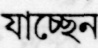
যাচ্ছেন
